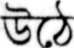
উঠে
